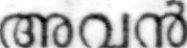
അവന്‍
